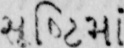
સુષ્ટિમાં
